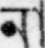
না
